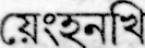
য়েংহনখি
